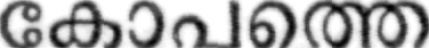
കോപത്തെ
